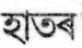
হাতৰ
